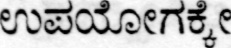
ಉಪಯೋಗಕ್ಕೇ
